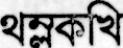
থম্লকখি
